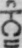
ਨੂੰ
